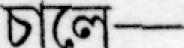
চালে-
